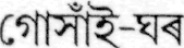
গোসাঁই-ঘৰ
